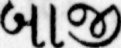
બાજી
